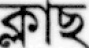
ক্লাছ
